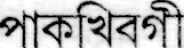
পাকখিবগী
